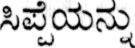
ಸಿಪ್ಪೆಯನ್ನು
